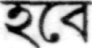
হবে
